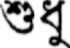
শুধু
